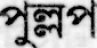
পুল্লপ
